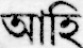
আহি
